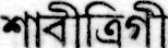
শাবীত্রিগী
